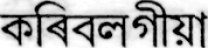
কৰিবলগীয়া
